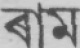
ৰাম
